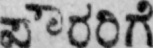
ಪೌರರಿಗೆ
